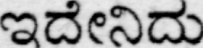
ಇದೇನಿದು
